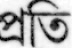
প্রতি
